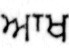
ਆਖ
